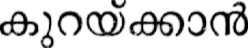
കുറയ്ക്കാന്‍
